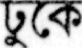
ঢুকে
